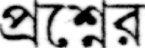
প্রশ্নের
